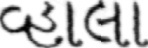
વ્હાલા
